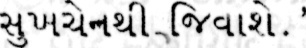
સુખચેનથી
